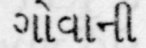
ગોવાની
